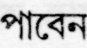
পাবেন
